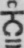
ਨੂੰ
